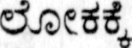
ಲೋಕಕ್ಕೆ
